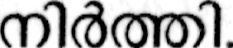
നിര്‍ത്തി.
